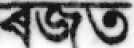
ৰজত
